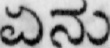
ಏನು
